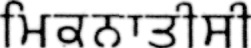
ਮਿਕਨਾਤੀਸੀ
